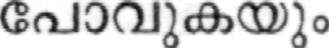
പോവുകയും
